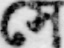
সে
